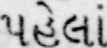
પહેલાં
